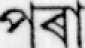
পৰা
